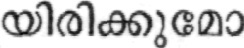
യിരിക്കുമോ
